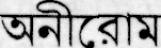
অনীরোম
